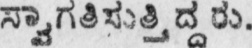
ಸ್ವಾಗತಿಸುತ್ತಿದ್ದರು.
